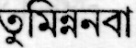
তুমিন্ননবা
